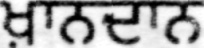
ਖ਼ਾਨਦਾਨ
